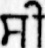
ਸੀ
